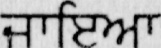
ਜਾਇਆ
